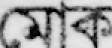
মোক
